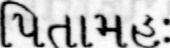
પિતામહઃ
